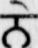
ਨੇ
